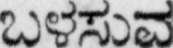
ಬಳಸುವ
